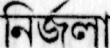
নির্জলা
